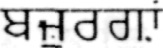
ਬਜ਼ੁਰਗਾਂ
